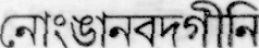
নোংঙানবদগীনি
